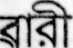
ৱারী
